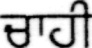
ਚਾਹੀ
